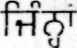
ਜਿੰਨ੍ਹਾਂ
